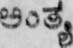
ಅಂತ್ಯ
